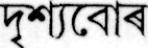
দৃশ্যবোৰ
